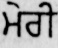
ਮੇਰੀ
